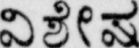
ವಿಶೇಷ
